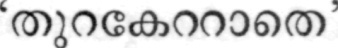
'തുറകേററാതെ'
